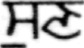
ਸੁਣ
